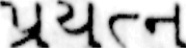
પ્રયત્ન
